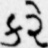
કરે
